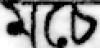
মচে
